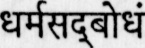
धर्मसद्बोधं
